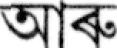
আৰু
